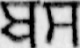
ਬਸ
